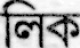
লিক
